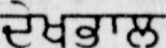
ਦੇਖਭਾਲ
